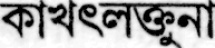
কাখৎলক্তুনা
